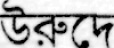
উরুদে
